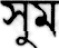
সুম
